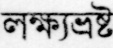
লক্ষ্যভ্রষ্ট
